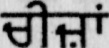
ਚੀਜ਼ਾਂ
